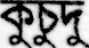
কুচুদু
